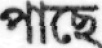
পাছে
